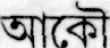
আকৌ
